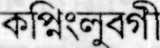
কপ্নিংলুবগী
